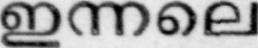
ഇന്നലെ
